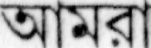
আমরা
